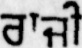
ਰਾਜੀ
